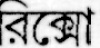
রিক্সো
